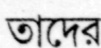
তাদের
